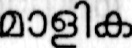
മാളിക
